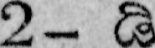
2-ಡಿ
